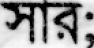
সার;
